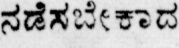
ನಡೆಸಬೇಕಾದ
